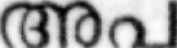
അപ
